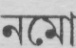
নমো
